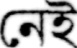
নেই
